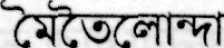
মৈতৈলোন্দা
